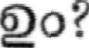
ഉം?
